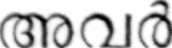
അവര്‍
